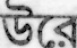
উরে
